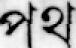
পথ
